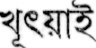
খূৎয়াই
